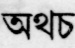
অথচ
